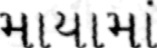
માયામાં
